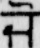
ਜੋ
